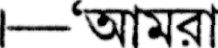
।-‘আমরা
